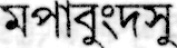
মপাবুংদসু
